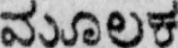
ಮೂಲಕ
